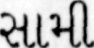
સામી
